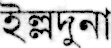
ইল্লদুনা
